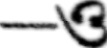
-ও
